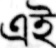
এই
